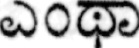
ಎಂಥಾ
